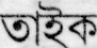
তাইক
